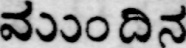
ಮುಂದಿನ
